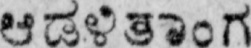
ಆಡಳಿತಾಂಗ
